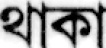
থাকা
